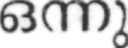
ഒന്നു
